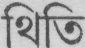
থিতি
